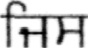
ਜਿਸ
